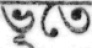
ভূতে
